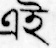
এই
